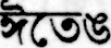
ঈতেঙ
